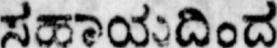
ಸಹಾಯದಿಂದ
